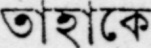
তাহাকে
